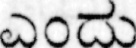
ಎಂದು
